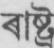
ৰাষ্ট্ৰ
